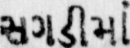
સગડીમાં
